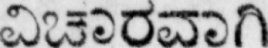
ವಿಚಾರವಾಗಿ
